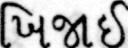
ખિજાઈ
